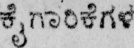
ಕೈಗಾರಿಕೆಗಳ
